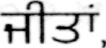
ਜੀਤਾਂ,
